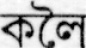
কলৈ
